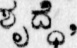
ಶೃದ್ಧೆ,
